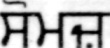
ਸੋਮਜ਼
